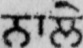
ਨਾਲੇ
